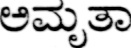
ಅಮೃತಾ
